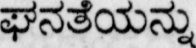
ಘನತೆಯನ್ನು
